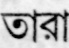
তারা
